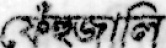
ফেঁহুজালি
